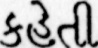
કહેતી
